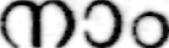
നാം
